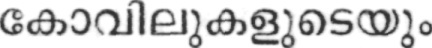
കോവിലുകളുടെയും
